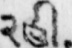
રહી.
